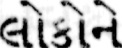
લોકોને
